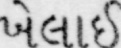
ખેલાઈ
